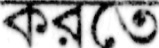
করতে
